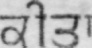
ਕੀਤਾ
